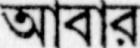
আবার
